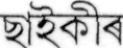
ছাইকীৰ
